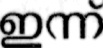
ഇന്ന്
